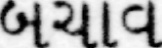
બચાવ
